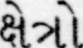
ક્ષેત્રો
